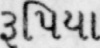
રૂપિયા
